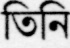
তিনি
